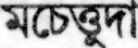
মচেত্তুদা
